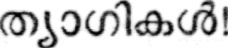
ത്യാഗികള്‍!
